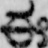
ಈ
